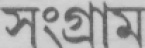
সংগ্ৰাম
